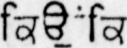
ਕਿਉਂਕਿ
